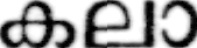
കലാ
